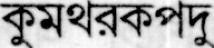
কুমথরকপদু
